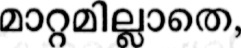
മാറ്റമില്ലാതെ,
